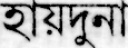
হায়দুনা
